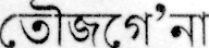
তৌজগে’না
